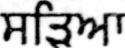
ਸੜਿਆ
